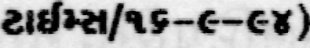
ટાઈમ્સ/૧૬-૯-૯૪)
